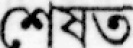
শেষত
